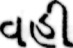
વહી
